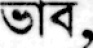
ভাব,
